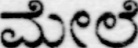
ಮೇಲೆ
